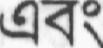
এবং
